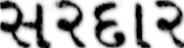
સરદાર
